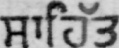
ਸਾਹਿੱਤ
